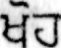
ਖੋਹ
